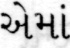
એમાં
